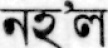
নহ'ল
